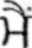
ਮੈਂ
